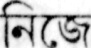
নিজে
